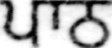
ਪਾਠ
